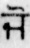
ਜੋ
